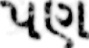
પણ
